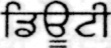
ਡਿਊਟੀ
